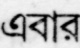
এবার
